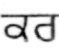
ਕਰ
